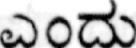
ಎಂದು
